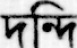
দন্দি
